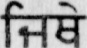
ਜਿਥੇ
